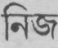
নিজ
